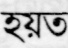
হয়ত
